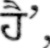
ਹੈ',
